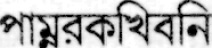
পাম্নরকখিবনি
